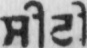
ਸੀਟੀ
